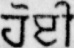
ਹੋਈ
